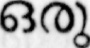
ഒരു
